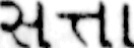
સત્તા
